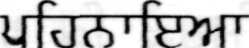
ਪਹਿਨਾਇਆ
